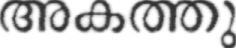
അകത്തു
